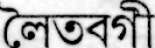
লৈতবগী
